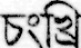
চংখ্রি
